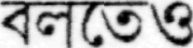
বলতেও
